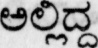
ಅಲ್ಲಿದ್ದ
